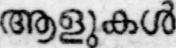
ആളുകള്‍
